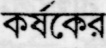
কর্ষকের
